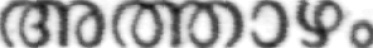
അത്താഴം
